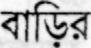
বাড়ির
